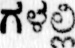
ಗಳಲ್ಲಿ
